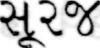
સૂરજ
